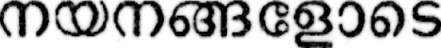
നയനങ്ങളോടെ
